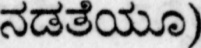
ನಡತೆಯೂ)
